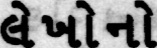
લેખોનો
